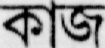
কাজ
